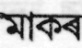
মাকৰ
